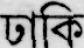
ঢাকি
